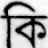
কি
